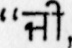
''ਜੀ,
